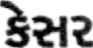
કેસર
